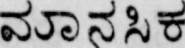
ಮಾನಸಿಕ
